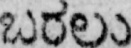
ಬರಲು
